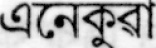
এনেকুৱা
